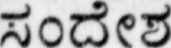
ಸಂದೇಶ
